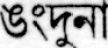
ঙংদুনা
